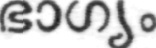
ഭാഗ്യം
